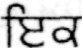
ਇਕ
